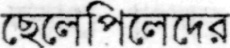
ছেলেপিলেদের
